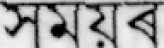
সময়ৰ
